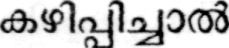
കഴിപ്പിച്ചാല്‍
